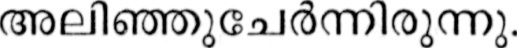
അലിഞ്ഞുചേര്‍ന്നിരുന്നു.
